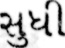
સુધી
